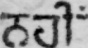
ਨਹੀਂ
